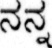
ನನ್ನ
